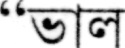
“ভাল
